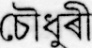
চৌধুৰী
